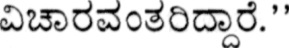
ವಿಚಾರವಂತರಿದ್ದಾರೆ."
